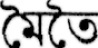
মৈতৈ
